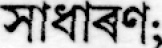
সাধাৰণ;
